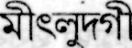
মীৎলুদগী
